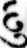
દુ
